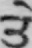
ਤੇ
